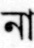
না
